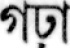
গঢ়া
